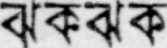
ঝকঝক
